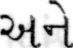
અને
